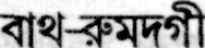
বাথ-রুমদগী
